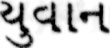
યુવાન
